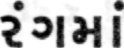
રંગમાં
